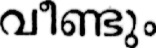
വീണ്ടും
